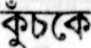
কুঁচকে
